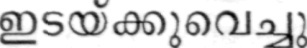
ഇടയ്ക്കുവെച്ചു
